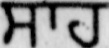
ਸਾਹ
